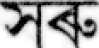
সৰু
